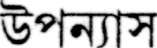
উপন্যাস
